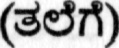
(ತಲೆಗೆ)
